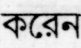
করেন
